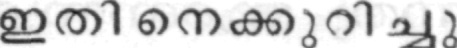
ഇതിനെക്കുറിച്ചു
